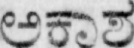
ಅಕಾಶ
